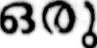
ഒരു
